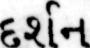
દર્શન
